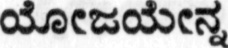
ಯೋಜಯೇನ್ನ
